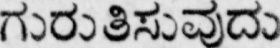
ಗುರುತಿಸುವುದು
